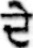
ਦੇ
